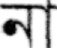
না
